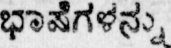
ಭಾಷೆಗಳನ್ನು
